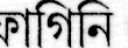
ফাগিনি
